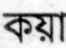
কয়া
